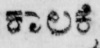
ಕಾಲಕ್ಕೆ
